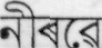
নীৰৱে
